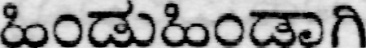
ಹಿಂಡುಹಿಂಡಾಗಿ
